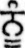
ਨੂੰ
